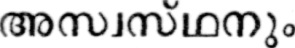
അസ്വസ്ഥനും
